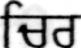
ਚਿਰ
